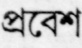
প্রবেশ
